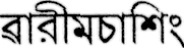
ৱারীমচাশিং
